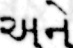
અને
